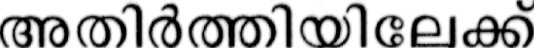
അതിര്‍ത്തിയിലേക്ക്
